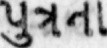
પુત્રના
